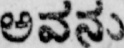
ಅವನು
